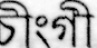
চীংগী
